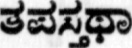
ತಪಸ್ತಥಾ
